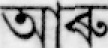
আৰু
